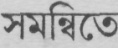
সমন্বিতে
